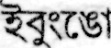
ইবুংঙো
